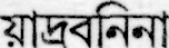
য়াদ্রবনিনা
